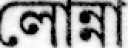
লোন্না
